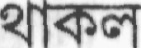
থাকল
